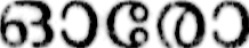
ഓരോ
